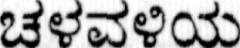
ಚಳವಳಿಯ
